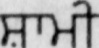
ਸ਼ਾਮੀ
